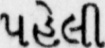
પહેલી
